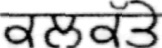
ਕਲਕੱਤੇ
